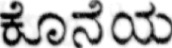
ಕೊನೆಯ
